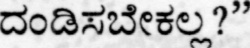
ದಂಡಿಸಬೇಕಲ್ಲ?"
